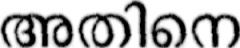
അതിനെ
